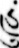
હું
